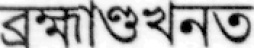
ব্রহ্মাণ্ডখনত
